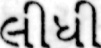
લીધી
